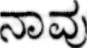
ನಾವು
